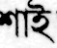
শাই
